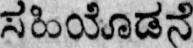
ಸಹಿಯೊಡನೆ
